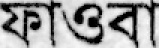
ফাওবা
